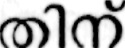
തിന്
